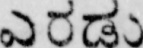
ಎರಡು
